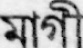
মাগী
